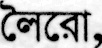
লৈরো,
